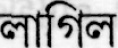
লাগিল
